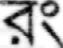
রং
